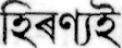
হিৰণ্যই
